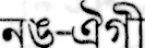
নঙ-ঐগী
